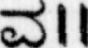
ವ||
